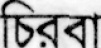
চিরবা
